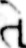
તે
